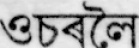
ওচৰলৈ
